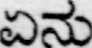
ಏನು
